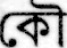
কৌ
